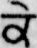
ਕੇ
